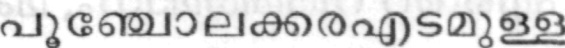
പൂഞ്ചോലക്കരഎടമുള്ള
